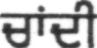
ਚਾਂਦੀ
